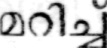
മറിച്ച്
